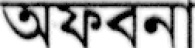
অফবনা
